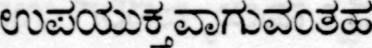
ಉಪಯುಕ್ತವಾಗುವಂತಹ
